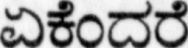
ಏಕೆಂದರೆ
